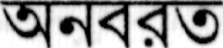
অনবরত
